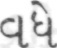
વધે
